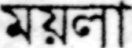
ময়লা
